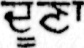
ਦੂਣਾ
